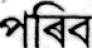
পৰিব
